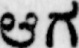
ಆಗ
